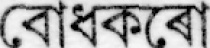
বোধকৰো
